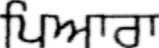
ਪਿਆਰਾ
